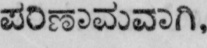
ಪರಿಣಾಮವಾಗಿ,
